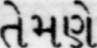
તેમણે
